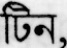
টিন,
